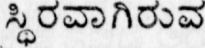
ಸ್ಥಿರವಾಗಿರುವ
